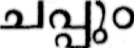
ചപ്പും
